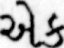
એક
